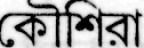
কৌশিরা
